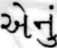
એનું
